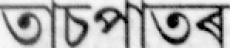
তাচপাতৰ
